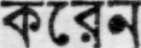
করেন
